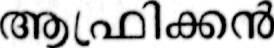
ആഫ്രിക്കന്‍
